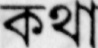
কথা
